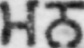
ਮਨ
